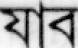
যাব
